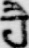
ਹੈ
